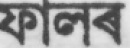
ফালৰ
